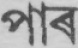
পাৰ
